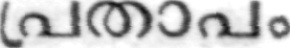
പ്രതാപം
